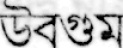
উবগুম
